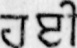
ਹਈ
